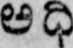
ಅಧಿ
